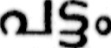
പട്ടം
